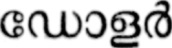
ഡോളര്‍
